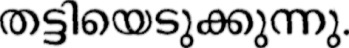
തട്ടിയെടുക്കുന്നു.
